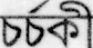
চর্চকী
